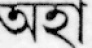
অহা
